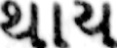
થાય
